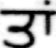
ਤਾਂ
